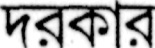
দরকার
